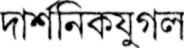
দার্শনিকযুগল
